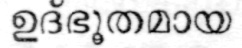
ഉദ്ഭൂതമായ
